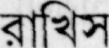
রাখিস
